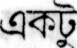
একটু
